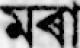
মৰা
